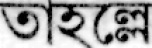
তাহল্লে
